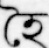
হৈ
